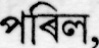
পৰিল,
